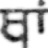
ਥਾਂ
